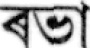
ৰভা
